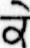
ਕੇ
